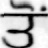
ਤੋਂ
